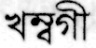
খম্বগী
